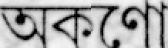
অকণো
